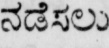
ನಡೆಸಲು
